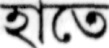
হাতে
